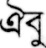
ঐবু
